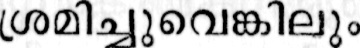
ശ്രമിച്ചുവെങ്കിലും
